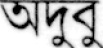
অদুবু
